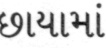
છાયામાં
